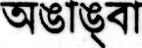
অঙাঙবা
